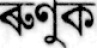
ৰুণুক
